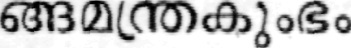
ങ്ങമന്ത്രകുംഭം
